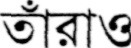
তাঁরাও
